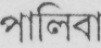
পালিবা
